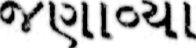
જણાવ્યા
